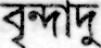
বৃন্দাদু
